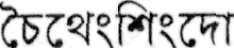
চৈথেংশিংদো
